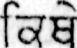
ਕਿਥੇ
